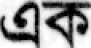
এক
